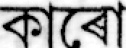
কাৰো
